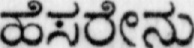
ಹೆಸರೇನು
